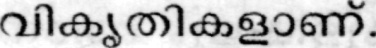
വികൃതികളാണ്.
